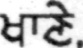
ਖਾਣੇ,
